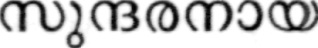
സുന്ദരനായ
